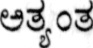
ಅತ್ಯಂತ
